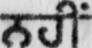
ਨਹੀਂ
